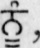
ਨੂੰ,
